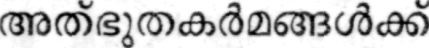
അത്ഭുതകര്‍മങ്ങള്‍ക്ക്
